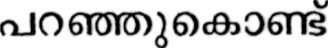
പറഞ്ഞുകൊണ്ട്
